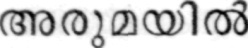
അരുമയില്‍
